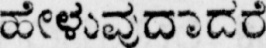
ಹೇಳುವುದಾದರೆ
